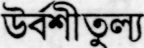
উর্বশীতুল্য
